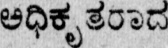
ಅಧಿಕೃತರಾದ
